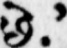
છે.'
